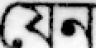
যেন
